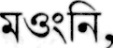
মওংনি,
